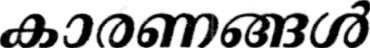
കാരണങ്ങള്‍
